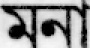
মনা
